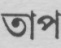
তাপ
